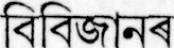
বিবিজানৰ
